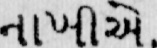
નાખીએ.
